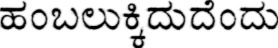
ಹಂಬಲುಕ್ಕಿದುದೆಂದು
